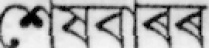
শেষবাৰৰ
